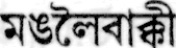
মঙলৈবাক্কী
